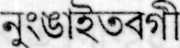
নুংঙাইতবগী
